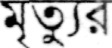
মৃত্যুর
